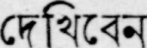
দেখিবেন
